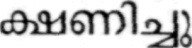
ക്ഷണിച്ചു
